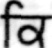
ਕਿ
